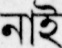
নাই
